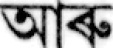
আৰু
